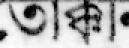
তোক্কা
